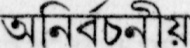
অনির্বচনীয়
